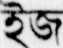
ইজ
